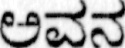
ಅವನ
